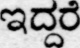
ಇದ್ದರೆ
